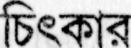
চিত্কার
